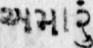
અમારું
